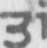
ਤਾਂ
